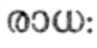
രാധ:
